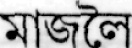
মাজলৈ
